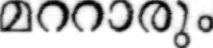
മററാരും
